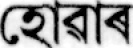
হোৱাৰ
